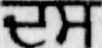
ਦਸ
